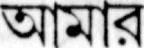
আমার
